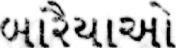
બારૈયાઓ
